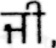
ਜੀ,
